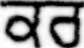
ਕਰ
